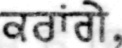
ਕਰਾਂਗੇ,
